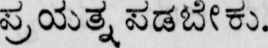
ಪ್ರಯತ್ನಪಡಬೇಕು.
